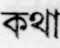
কথা
